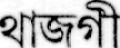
থাজগী
